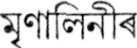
মৃণালিনীৰ
